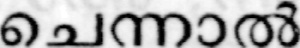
ചെന്നാല്‍
